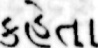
કહેતા
